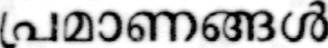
പ്രമാണങ്ങള്‍
